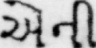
એની
